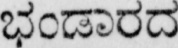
ಭಂಡಾರದ
